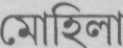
মোহিলা
